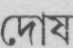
দোষ
